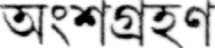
অংশগ্রহণ
